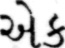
એક
